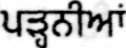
ਪੜ੍ਹਨੀਆਂ
